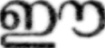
ഈ
